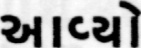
આવ્યો
